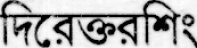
দিরেক্তরশিং
